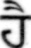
ਹੈ
